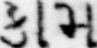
કામ
